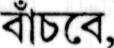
বাঁচবে,
